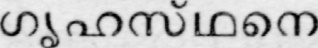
ഗൃഹസ്ഥനെ
